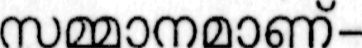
സമ്മാനമാണ്-
